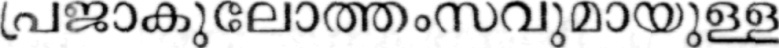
പ്രജാകുലോത്തംസവുമായുള്ള
